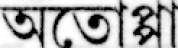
অতোপ্পা
